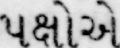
પક્ષોએ
